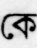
কে
